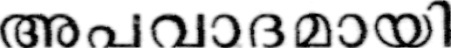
അപവാദമായി
